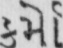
કર્મો
